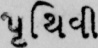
પૃથિવી
